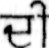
ਦੀ
